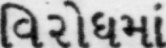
વિરોધમાં
